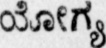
ಯೋಗ್ಯ
